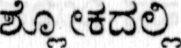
ಶ್ಲೋಕದಲ್ಲಿ
